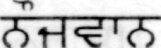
ਨੌਜਵਾਨ
